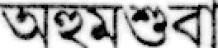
অহুমশুবা
